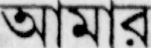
আমার
